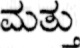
ಮತ್ತು
